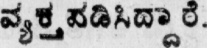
ವ್ಯಕ್ತಪಡಿಸಿದ್ದಾರೆ.
